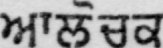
ਆਲੋਚਕ
